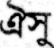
ঐসু
